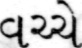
વચ્ચે
